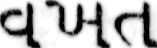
વખત
